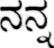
ನನ್ನ
